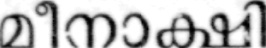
മീനാക്ഷി
